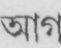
আগ
